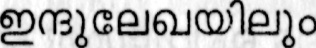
ഇന്ദുലേഖയിലും
